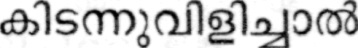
കിടന്നുവിളിച്ചാല്‍
